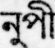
নুপী
